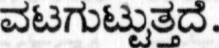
ವಟಗುಟ್ಟುತ್ತದೆ.
